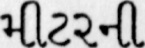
મીટરની
